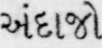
અંદાજો
